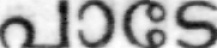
പാടേ
